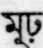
মূঢ়
